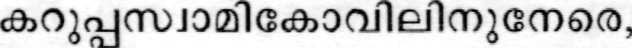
കറുപ്പസ്വാമികോവിലിനുനേരെ,
